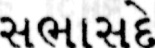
સભાસદે
